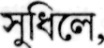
সুধিলে,
